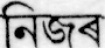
নিজৰ
